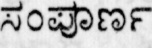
ಸಂಪೂರ್ಣ
